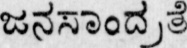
ಜನಸಾಂದ್ರತೆ
